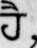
ਹੈ,
